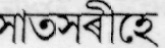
সাতসৰীহে
